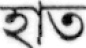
হাত
